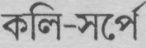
কলি-সৰ্পে
